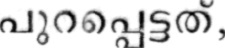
പുറപ്പെട്ടത്,
